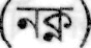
(নক্ন)
